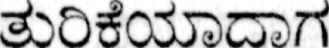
ತುರಿಕೆಯಾದಾಗ
